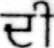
ਦੀ
